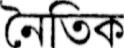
নৈতিক
